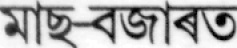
মাছ-বজাৰত
